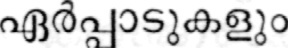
ഏര്‍പ്പാടുകളും
